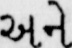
અને
